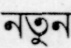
নতুন
